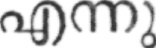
എന്നു
